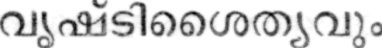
വൃഷ്ടിശൈത്യവും
